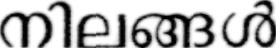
നിലങ്ങള്‍
